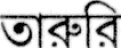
তারুরি
